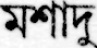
মশাদু
